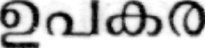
ഉപകര
